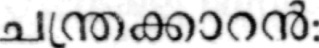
ചന്ത്രക്കാറന്‍:
